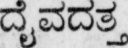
ದೈವದತ್ತ
